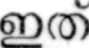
ഇത്
